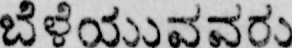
ಬೆಳೆಯುವವರು
